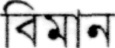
বিমান
